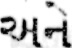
અને
